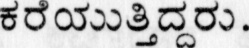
ಕರೆಯುತ್ತಿದ್ದರು.
